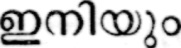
ഇനിയും
